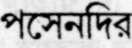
পসেনদির
